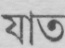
যাত
